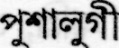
পুশালুগী
